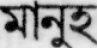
মানুহ
